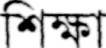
শিক্ষা
